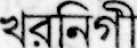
খরনিগী
